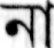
না
